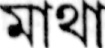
মাথা
